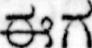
ಈಗ
